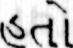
હતો
